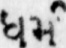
ધર્મ
